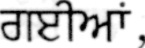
ਗਈਆਂ,
